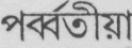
পৰ্ব্বতীয়া
